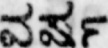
ವರ್ಷ
